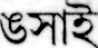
ঙসাই
